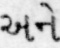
અને
